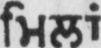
ਮਿਲਾਂ
